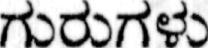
ಗುರುಗಳು
